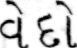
વેદો
